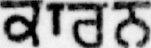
ਕਾਰਨ
